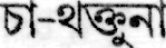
চা-থক্তুনা
